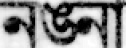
নঙনা
